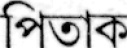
পিতাক
